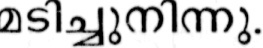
മടിച്ചുനിന്നു.
